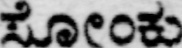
ಸೋಂಕು
